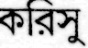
করিসু
